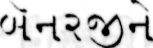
બૅનરજીને
